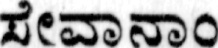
ಸೇವಾನಾಂ
